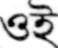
ওই
